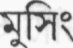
মুসিং
